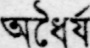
অধৈর্য
